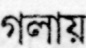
গলায়
